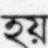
হয়
